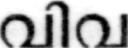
വിവ
